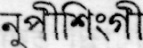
নুপীশিংগী
